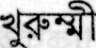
খুরুম্মী
